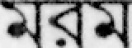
মরম
